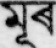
মূৰ
